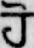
ਹੋ
